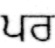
ਪਰ
